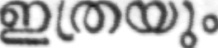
ഇത്രയും
